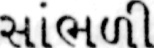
સાંભળી
